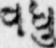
વધુ
